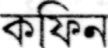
কফিন
